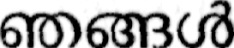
ഞങ്ങള്‍
